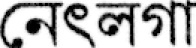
নেৎলগা
